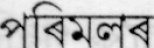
পৰিমলৰ
